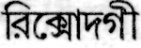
রিক্সোদগী
